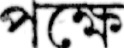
পক্ষে
